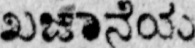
ಖಜಾನೆಯ
